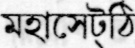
মহাসেট্ঠি
